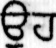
ਉਹ
